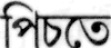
পিচতে
